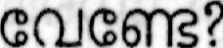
വേണ്ടേ?
